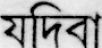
যদিবা
